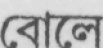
বোলে
